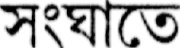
সংঘাতে
